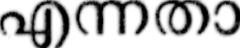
എന്നതാ
